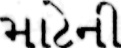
માટેની
